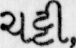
ચટ્ટી,
